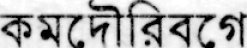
কমদৌরিবগে
